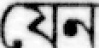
যেন
